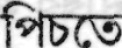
পিচতে
